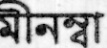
মীনম্বা
